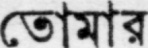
তোমার
